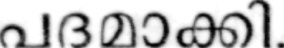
പദമാക്കി.
